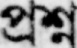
প্রশ্ন
